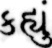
કહ્યું
